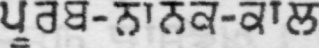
ਪੂਰਬ-ਨਾਨਕ-ਕਾਲ
